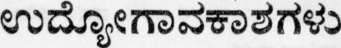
ಉದ್ಯೋಗಾವಕಾಶಗಳು
